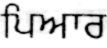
ਪਿਆਰ
